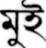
মুই
